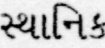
સ્થાનિક
